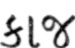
કાજ
